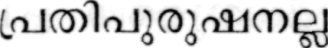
പ്രതിപുരുഷനല്ല
